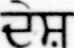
ਦੇਸ਼
